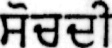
ਸੋਚਦੀ
